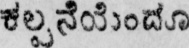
ಕಲ್ಪನೆಯೆಂದೂ
